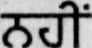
ਨਹੀਂ
